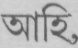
আহি,
